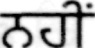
ਨਹੀਂ
